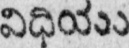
ವಿಧಿಯು
